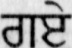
ਗਏ
